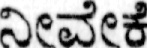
ನೀವೇಕೆ
